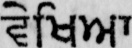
ਵੇਖਿਆ
